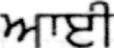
ਆਈ
